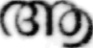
ആ
